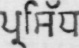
ਪ੍ਰਸਿੱਧ
